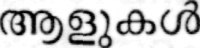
ആളുകള്‍
